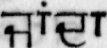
ਜਾਂਦਾ
